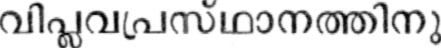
വിപ്ലവപ്രസ്ഥാനത്തിനു
